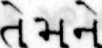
તેમને
